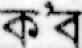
ক'ব
